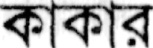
কাকার
